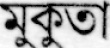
মুকুতা
